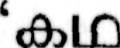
'കഥ
